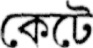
কেটে
